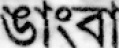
ঙাংবা
